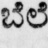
ಬೆಲೆ
